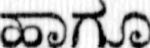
ಹಾಗೂ
